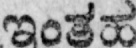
ಇಂತಹ
